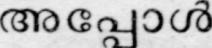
അപ്പോള്‍
